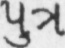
પુત્ર
